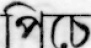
পিচে
